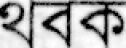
থবক
